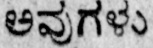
ಅವುಗಳು
